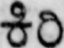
ಕಿರಿ
